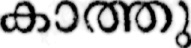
കാത്തു
